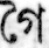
গৈ
